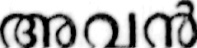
അവന്‍
